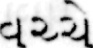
વચ્ચે
